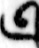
এ
